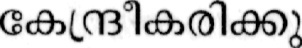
കേന്ദ്രീകരിക്കു
